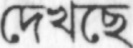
দেখছে
